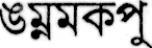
ঙম্নমকপু
